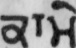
ਕਾਮੇ
